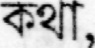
কথা,
